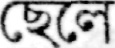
ছেলে
